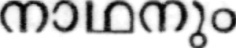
നാഥനും
